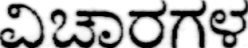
ವಿಚಾರಗಳ
